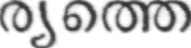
ര്യത്തെ
